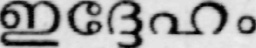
ഇദ്ദേഹം
